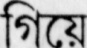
গিয়ে
